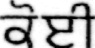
ਕੋਈ
